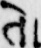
તો
